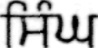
ਸਿੰਘ
